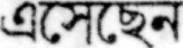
এসেছেন
